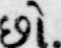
છો.
